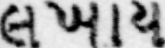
લખાય
